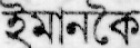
ইমানকৈ
